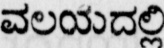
ವಲಯದಲ್ಲಿ
